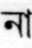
না
